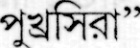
পুখ্রসিরা”
